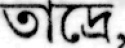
তাদ্রে,
